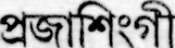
প্রজাশিংগী
